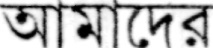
আমাদের
